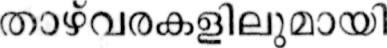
താഴ്വരകളിലുമായി
